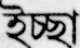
ইচ্ছা
